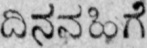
ದಿನವಹಿಗೆ
